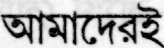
আমাদেরই
